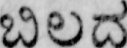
ಬಿಲದ
